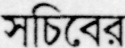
সচিবের
